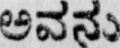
ಅವನು
